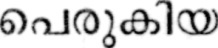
പെരുകിയ
